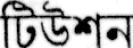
টিউশন
